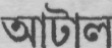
আটাল
